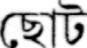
ছোট
